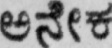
ಅನೇಕ
